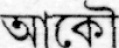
আকৌ
